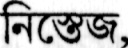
নিস্তেজ,
